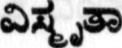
ವಿಸ್ಮೃತಾ
